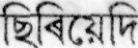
ছিৰিয়েদি
